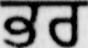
ਭਰ
